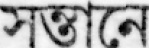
সন্তানে
